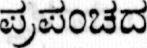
ಪ್ರಪಂಚದ
